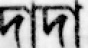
দাদা
